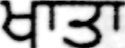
ਖਾਤਾ
